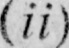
(ii)
